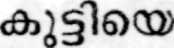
കുട്ടിയെ
